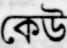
কেউ
